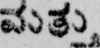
ಮತ್ತು
